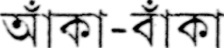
আঁকা-বাঁকা
